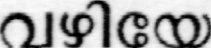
വഴിയേ
